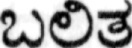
ಬಲಿತ
